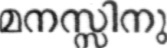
മനസ്സിനു
